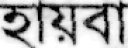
হায়বা
